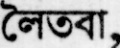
লৈতবা,
